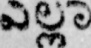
ಎಲ್ಲಾ
